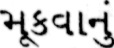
મૂકવાનું
